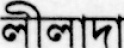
লীলাদা
